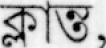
ক্লান্ত,
